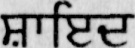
ਸ਼ਾਇਦ
